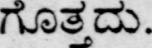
ಗೊತ್ತದು.
